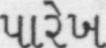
પારેખ
